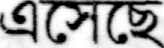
এসেছে
